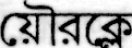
য়ৌরক্লে
